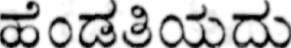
ಹೆಂಡತಿಯದು
